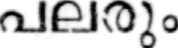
പലരും
